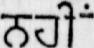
ਨਹੀਂ
